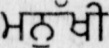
ਮਨੁੱਖੀ
